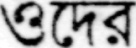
ওদের
